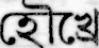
হৌখ্রে
